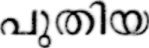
പുതിയ
